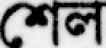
শেল
